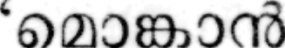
'മൊങ്കാന്‍
